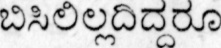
ಬಿಸಿಲಿಲ್ಲದಿದ್ದರೂ
